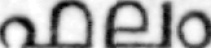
ഫലം
